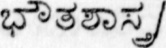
ಭೌತಶಾಸ್ತ್ರ/
